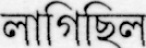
লাগিছিল
